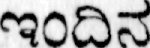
ಇಂದಿನ
